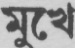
মুখে
